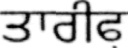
ਤਾਰੀਫ਼
